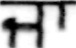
ਜਾ
